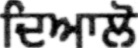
ਦਿਆਲੋ
